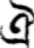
ঐ
